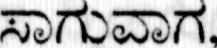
ಸಾಗುವಾಗ,
